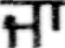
ਜਾ
